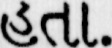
હતા.
